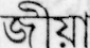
জীয়া
